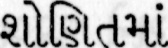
શોણિતમાં
